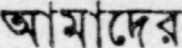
আমাদের
